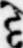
દે
